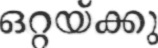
ഒറ്റയ്ക്കു
